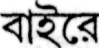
বাইরে
